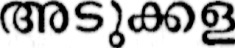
അടുക്കള
